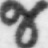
જ
